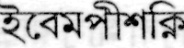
ইবেমপীশক্নি
